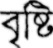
বৃষ্টি
